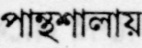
পান্থশালায়
